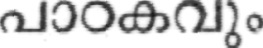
പാഠകവും
